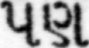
પણ
